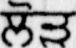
ਲੋੜ
